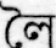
লৈ
